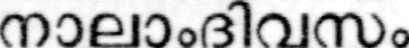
നാലാംദിവസം
